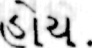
હોય.
